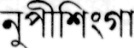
নুপীশিংগা
